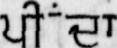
ਪੀਂਦਾ
